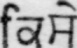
ਕਿਸੇ
